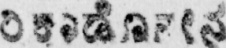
ರಿಕಾರ್ಡೋನ
